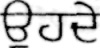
ਉਹਦੇ
